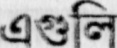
এগুলি
